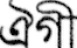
ঐগী
